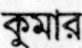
কুমার
